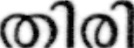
തിരി
